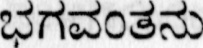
ಭಗವಂತನು
